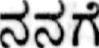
ನನಗೆ
